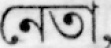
নেতা,
